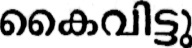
കൈവിട്ടു
